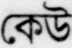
কেউ
